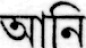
আনি
